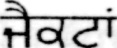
ਜੈਕਟਾਂ
